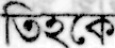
তিহকে
